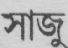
সাজু
